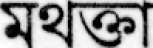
মথক্তা
